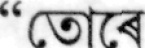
"তোৰে
